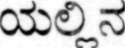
ಯಲ್ಲಿನ
